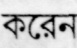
করেন
